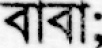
বাবা;
